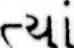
ત્યાં
